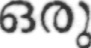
ഒരു
